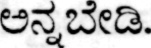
ಅನ್ನಬೇಡಿ.
